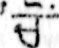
'ਚੋਂ
